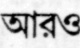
আরও
